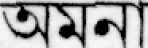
অমনা
